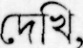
দেখি,
